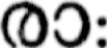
രാ:
